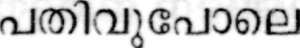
പതിവുപോലെ
